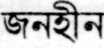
জনহীন
